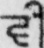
ਵੀ
